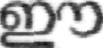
ഈ
